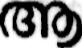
ആ
